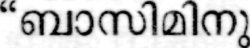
“ബാസിമിനു
